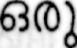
ഒരു
